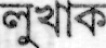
লুখাক
